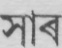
সাৰ
